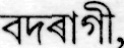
বদৰাগী,
